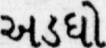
અડધો
